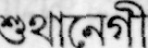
শুথানেগী
